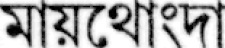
মায়থোংদা
